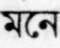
মনে
